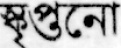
স্কৃপ্তনো
